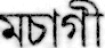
মচাগী
